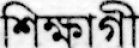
শিক্ষাগী
